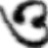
ও
